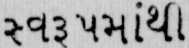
સ્વરૂપમાંથી
